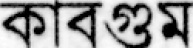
কাবগুম
